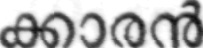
ക്കാരന്‍
